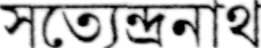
সত্যেন্দ্রনাথ
